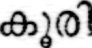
കൂരി
